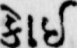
કોઈ
